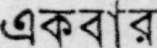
একবার
